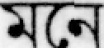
মনে
